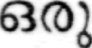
ഒരു
